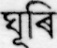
ঘূৰি
